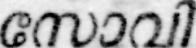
സോവി
